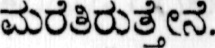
ಮರೆತಿರುತ್ತೇನೆ.
